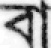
বা
